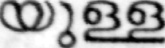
യുള്ള
